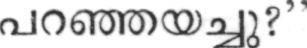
പറഞ്ഞയച്ചു?"
